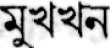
মুখখন
